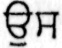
ਉਸ
